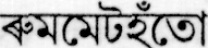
ৰুমমেটহঁতো
